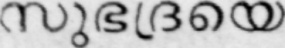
സുഭദ്രയെ
